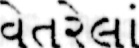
વેતરેલાં
